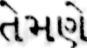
તેમણે
